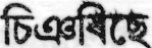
চিঞৰিছে
